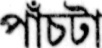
পাঁচটা
